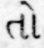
તો
